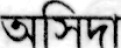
অসিদা
